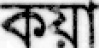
কয়া
